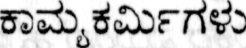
ಕಾಮ್ಯಕರ್ಮಿಗಳು
